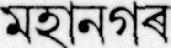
মহানগৰ
